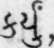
કર્યું,
